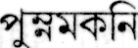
পুম্নমকনি
